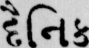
દૈનિક
